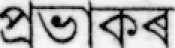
প্রভাকৰ
